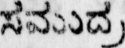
ಸಮುದ್ರ
